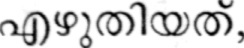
എഴുതിയത്,
